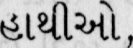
હાથીઓ,
